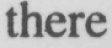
there
